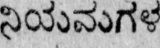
ನಿಯಮಗಳ
